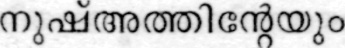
നുഷ്അത്തിന്റേയും
